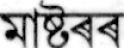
মাষ্টৰৰ
